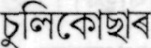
চুলিকোছাৰ
